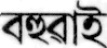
বহুৱাই
